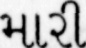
મારી
